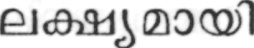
ലക്ഷ്യമായി
